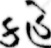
કહે
